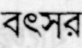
বত্সর
